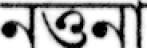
নত্তনা
